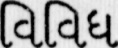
વિવિધ
